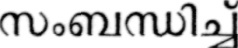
സംബന്ധിച്ച്
